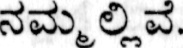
ನಮ್ಮಲ್ಲಿವೆ.
